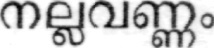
നല്ലവണ്ണം
